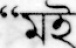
"মই
